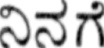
ನಿನಗೆ
